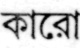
কারো
